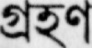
গ্রহণ
